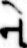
ને
